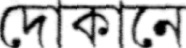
দোকানে
